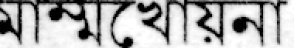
মাম্মখোয়না
